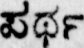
ಪರ್ಥ
